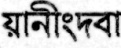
য়ানীংদবা
